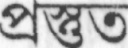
প্রস্তুত
